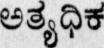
ಅತ್ಯಧಿಕ
